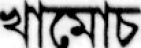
খামোচ
